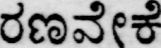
ರಣವೇಕೆ
